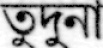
তুদুনা
